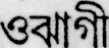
ওঝাগী
